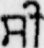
ਸੀ
